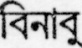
বিনাবু
